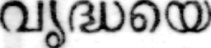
വൃദ്ധയെ
